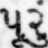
પૂરું
